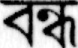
বন্ধ
